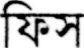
ফিস
